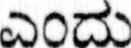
ಎಂದು
